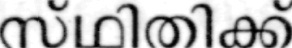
സ്ഥിതിക്ക്
